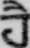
ਹੈ
